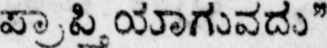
ಪ್ರಾಪ್ತಿಯಾಗುವದು”
